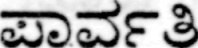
ಪಾರ್ವತಿ
